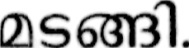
മടങ്ങി.
